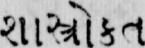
શાસ્ત્રોક્ત
